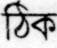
ঠিক
